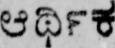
ಆರ್ಥಿಕ
